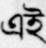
এই
